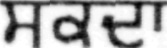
ਸਕਦਾ
